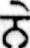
ਨੇ
